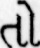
તો
